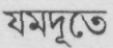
যমদূতে
